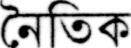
নৈতিক
